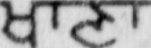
ਖਾਣਾ
